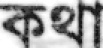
কথা
